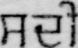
ਸਦੀ
